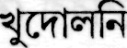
খুদোলনি
